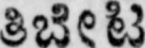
ತಿಬೇಟಿ
